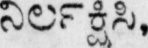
ನಿರ್ಲಕ್ಷಿಸಿ,
